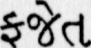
ફજેત
